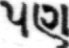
પણ
